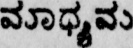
ಮಾಧ್ಯಮ
